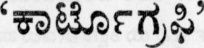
‘ಕಾರ್ಟೊಗ್ರಫಿ’
